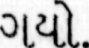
ગયો.
